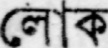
লোক
